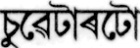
চুৱেটাৰটো
